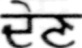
ਦੇਣ
